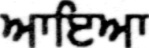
ਆਇਆ
